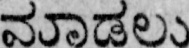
ಮಾಡಲು
